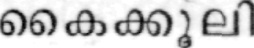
കൈക്കൂലി
